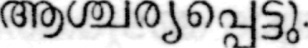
ആശ്ചര്യപ്പെട്ടു.
